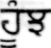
ਹੂੰਝ
